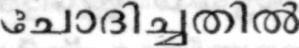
ചോദിച്ചതില്‍
